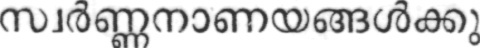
സ്വര്‍ണ്ണനാണയങ്ങള്‍ക്കു
